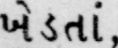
ખેડતાં,
